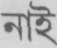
নাই
